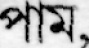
পাম,
